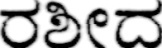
ರಶೀದ
